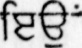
ਇਉਂ
